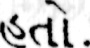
હતો.
